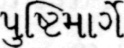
પુષ્ટિમાર્ગે
